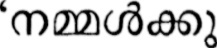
‘നമ്മള്‍ക്കു
